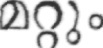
മറ്റും
